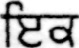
ਇਕ
